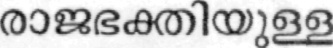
രാജഭക്തിയുള്ള
